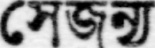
সেজন্য
